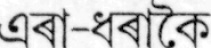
এৰা-ধৰাকৈ
